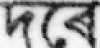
দৰে
